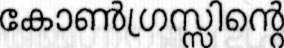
കോണ്‍ഗ്രസ്സിന്റെ
